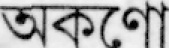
অকণো
